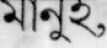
মানুহ,
